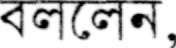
বললেন
